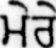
ਮੇਰੇ
